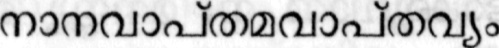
നാനവാപ്തമവാപ്തവ്യം
